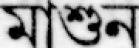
মাশুন
